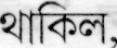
থাকিল,
